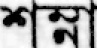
শম্না
